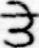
ਤੇ
